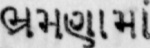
ભ્રમણામાં
